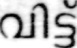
വിട്ട്
